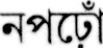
নপঢ়োঁ
